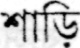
শাড়ি
